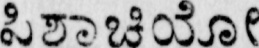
ಪಿಶಾಚಿಯೋ
